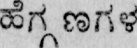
ಹೆಗ್ಗಣಗಳ
